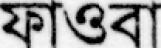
ফাওবা
